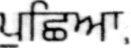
ਪੁਛਿਆ,
